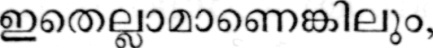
ഇതെല്ലാമാണെങ്കിലും,
